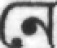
নে
